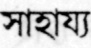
সাহায্য
